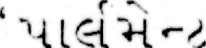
'પાર્લમેન્ટ
